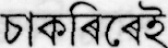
চাকৰিৰেই
